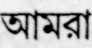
আমরা
